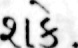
શકે.
